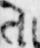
તો
